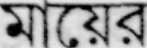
মায়ের
